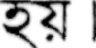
হয়।
